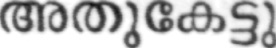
അതുകേട്ടു
